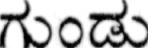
ಗುಂಡು
